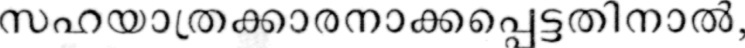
സഹയാത്രക്കാരനാക്കപ്പെട്ടതിനാല്‍,
